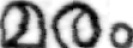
മരം
